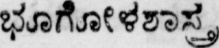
ಭೂಗೋಳಶಾಸ್ತ್ರ
